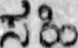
ಸಹಿ
